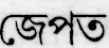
জেপত
